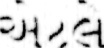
એટલે
